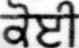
ਕੋਈ
